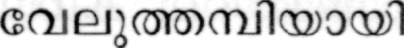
വേലുത്തമ്പിയായി
